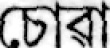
চোৱা
